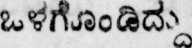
ಒಳಗೊಂಡಿದ್ದು
